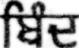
ਬਿੰਦ
